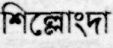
শিল্লোংদা
